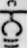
ਨੂੰ
